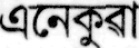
এনেকুৱা
